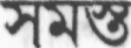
সমস্ত
